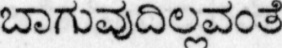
ಬಾಗುವುದಿಲ್ಲವಂತೆ
